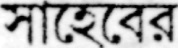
সাহেবের
